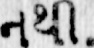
નથી.
